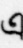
এ
